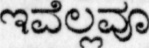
ಇವೆಲ್ಲವೂ
